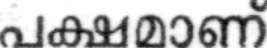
പക്ഷമാണ്
